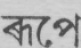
ৰূপে
